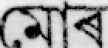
মোৰ
